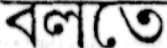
বলতে
